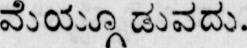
ಮೆಯ್ಗೂಡುವದು.
